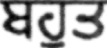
ਬਹੁਤ
